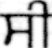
ਸੀ
